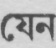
যেন
